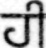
ਹੀ
